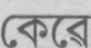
কেৱে
